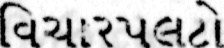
વિચારપલટો
